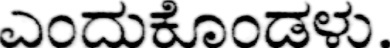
ಎಂದುಕೊಂಡಳು.
